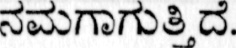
ನಮಗಾಗುತ್ತಿದೆ.
